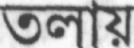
তলায়
